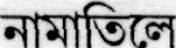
নামাতিলে
